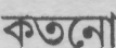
কতনো
